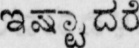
ಇಷ್ಟಾದರೆ
